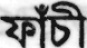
ফাঁচী
